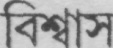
বিশ্বাস
